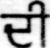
ਦੀ
